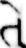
તે
